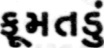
કૂમતડું
